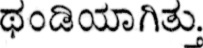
ಥಂಡಿಯಾಗಿತ್ತು.
